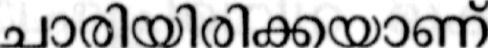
ചാരിയിരിക്കയാണ്
